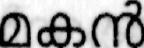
മകന്‍
